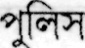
পুলিস
